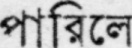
পারিলে
